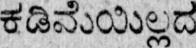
ಕಡಿಮೆಯಿಲ್ಲದ
